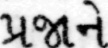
પ્રજાને
